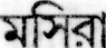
মসিরা
